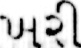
ખરી
